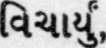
વિચાર્યું,
